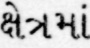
ક્ષેત્રમાં
